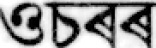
ওচৰৰ
